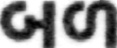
બળ
